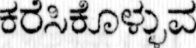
ಕರೆಸಿಕೊಳ್ಳುವ
